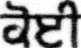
ਕੋਈ
